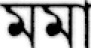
মমা
